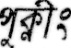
পুক্নীং
